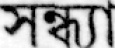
সন্ধ্যা
